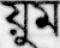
য়ুম
